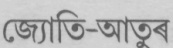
জ্যোতি-আতুৰ
